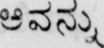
ಅವನ್ನು
